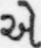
એ
